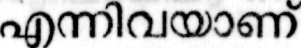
എന്നിവയാണ്
